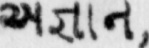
અજ્ઞાન,
